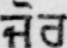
ਜੋਰ
